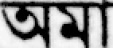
অমা
